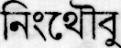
নিংথৌবু
